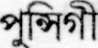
পুন্সিগী
